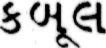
કબૂલ
